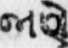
જાણે
